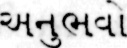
અનુભવો
